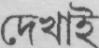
দেখাই
